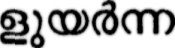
ളുയര്‍ന്ന
